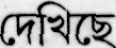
দেখিছে
